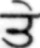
ਤੇ
